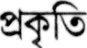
প্রকৃতি
